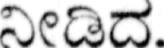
ನೀಡಿದ.
